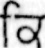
ਕਿ
